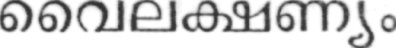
വൈലക്ഷണ്യം
